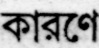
কারণে
